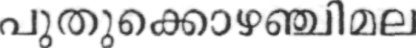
പുതുക്കൊഴഞ്ചിമല
